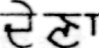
ਦੇਣਾ
